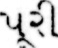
પૂરી
